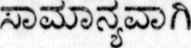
ಸಾಮಾನ್ಯವಾಗಿ
